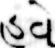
હવે
